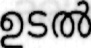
ഉടല്‍
